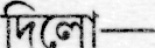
দিলো-
